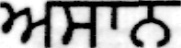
ਅਸਾਨ
